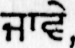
ਜਾਵੇ,
